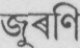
জুৰণি
